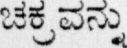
ಚಕ್ರವನ್ನು
